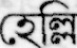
হেল্লি
